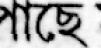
পাছে
